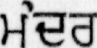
ਮੰਦਰ
